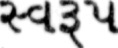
સ્વરૂપ
